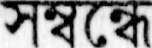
সম্বন্ধে
